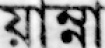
য়াম্না
